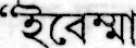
“ইবেম্মা
